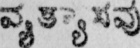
ವ್ಯತ್ಯಾಸವು
